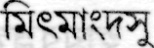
মিৎমাংদসু
